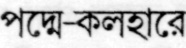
পদ্মে-কলহারে
